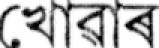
খোৱাৰ
